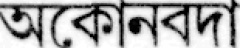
অকোনবদা
